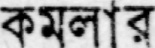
কমলার
